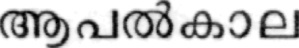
ആപല്‍കാല
